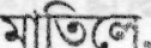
মাতিলে,
